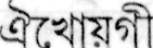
ঐখোয়গী
